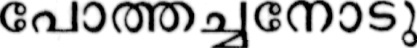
പോത്തച്ചനോടു
